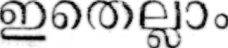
ഇതെല്ലാം
